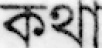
কথা
